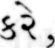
કરે,
